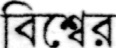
বিশ্বের
